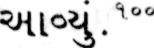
આવ્યું.૧૦૦
